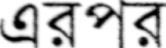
এরপর
